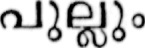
പുല്ലും
